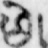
છો
